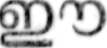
ഈ
